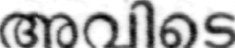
അവിടെ
